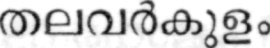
തലവര്‍കുളം
